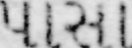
પાસા
